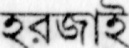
হরজাই
